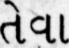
તેવા
